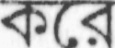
করে
